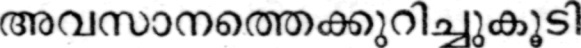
അവസാനത്തെക്കുറിച്ചുകൂടി
